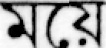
ময়ে
